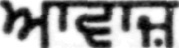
ਆਵਾਜ਼
